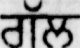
ਗੱਲ
